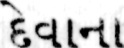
દેવાના
